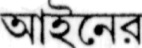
আইনের
